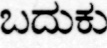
ಬದುಕು
